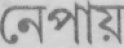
নেপায়
